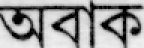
অবাক
